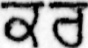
ਕਰ
